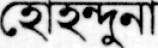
হোহন্দুনা
